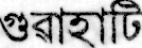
গুৱাহাটি
